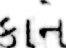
કાને
